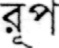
রূপ
